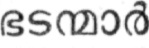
ഭടന്മാര്‍
